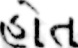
હોત
